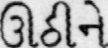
ઊઠીને
